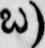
ಬ)
